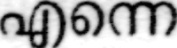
എന്നെ
